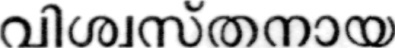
വിശ്വസ്തനായ
